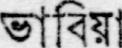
ভাবিয়া
